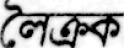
লৈক্রক
